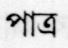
পাত্র
